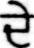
ਦੇ
